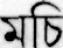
মচি
